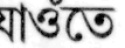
যাওঁতে
